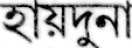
হায়দুনা
